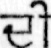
ਦੀ
